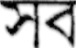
সব
